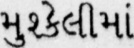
મુશ્કેલીમાં
